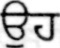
ਉਹ
